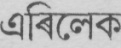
এৰিলেক
